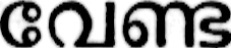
വേണ്ട
